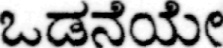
ಒಡನೆಯೇ
